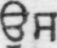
ਉਸ
